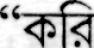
“করি
